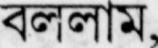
বললাম,
